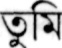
তুমি
